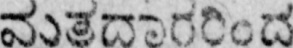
ಮತದಾರರಿಂದ
